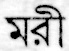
মরী
